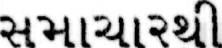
સમાચારથી
